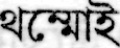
থম্মোই
